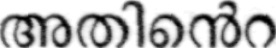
അതിന്റെ
